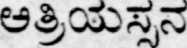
ಅತ್ರಿಯಸ್ಸನ
